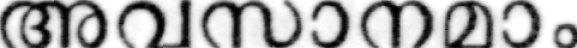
അവസാനമാം
